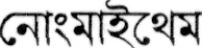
নোংমাইথেম
